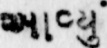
આવ્યું
